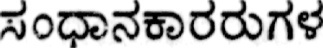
ಸಂಧಾನಕಾರರುಗಳ
